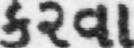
કરવા
